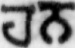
ਹਨ
